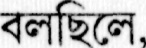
বলছিলে,
